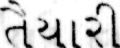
તૈયારી
